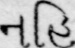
નહિ
